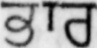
ਭਾਰ
